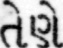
તેણે
